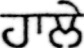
ਹਾਲੇ
